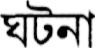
ঘটনা
